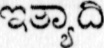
ಇತ್ಯಾದಿ
